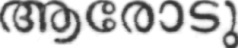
ആരോടു
